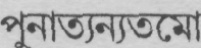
পুনাত্যন্যতমো
